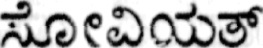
ಸೋವಿಯತ್
